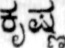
ಕೃಷ್ಣ
